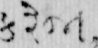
કરેજા,
